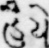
હૈયે
